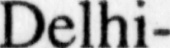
Delhi-
